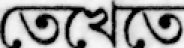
তেখেতে
